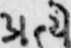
પ્રત્યે
